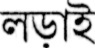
লড়াই
